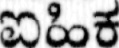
ಐಹಿಕ
